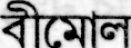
বীমোল
